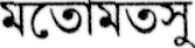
মতোমতসু
